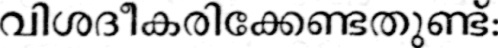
വിശദീകരിക്കേണ്ടതുണ്ട്:
